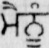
ਮੈਨੂੰ
